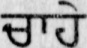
ਚਾਹੇ
